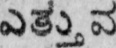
ಎತ್ತುವ
